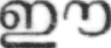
ഈ
